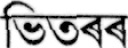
ভিতৰৰ
